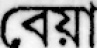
বেয়া
